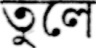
তুলে
